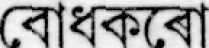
বোধকৰো
